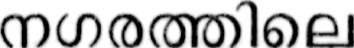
നഗരത്തിലെ
